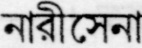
নারীসেনা
